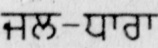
ਜਲ-ਧਾਰਾ
